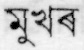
মুখৰ
